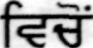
ਵਿਚੋਂ
